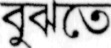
বুঝতে
